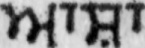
ਆਸ਼ਾ
